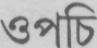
ওপচি
